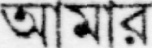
আমার
